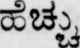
ಹೆಚ್ಚು
